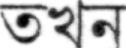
তখন
